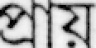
প্রায়
